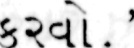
કરવો.'
